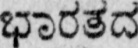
ಭಾರತದ
